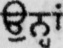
ਉਨ੍ਹਾਂ
